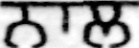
ਨਾਲ
